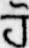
ਹੋ
